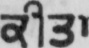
ਕੀਤਾ
